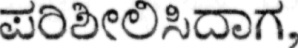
ಪರಿಶೀಲಿಸಿದಾಗ,
